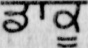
ਡਾਕੂ
